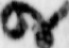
જ
